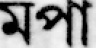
মপা
